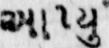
આપ્યું
